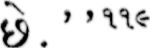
છે."૧૧૯
